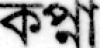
কপ্না
